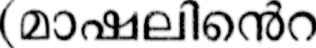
(മാഷലിന്റെ
